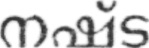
നഷ്ട
